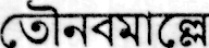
তৌনবমাল্লে
